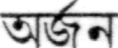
অর্জন
